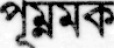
পূম্নমক
